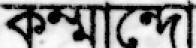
কম্মান্দো
